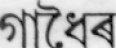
গাধৈৰ
